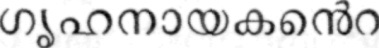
ഗൃഹനായകന്റെ
